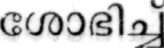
ശോഭിച്ച്
